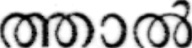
ത്താല്‍
